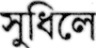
সুধিলে
